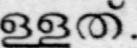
ള്ളത്.
